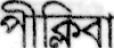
পীক্লিবা
